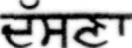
ਦੱਸਣਾ
